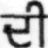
ਦੀ
